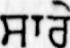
ਸਾਰੇ
